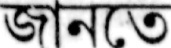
জানতে
